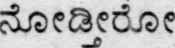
ನೋಡ್ತೀರೋ
